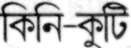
কিনি-কুটি
